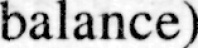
balance)
